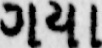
ગયા
